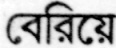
বেরিয়ে
